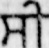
ਸੀ
